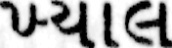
ખ્યાલ
